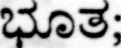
ಭೂತ;
